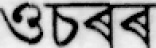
ওচৰৰ
